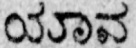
ಯಾವ
